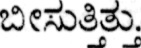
ಬೀಸುತ್ತಿತ್ತು.
